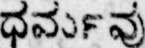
ಧರ್ಮವು
